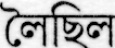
লৈছিল
